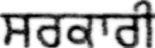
ਸਰਕਾਰੀ
